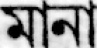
মানা
